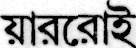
য়াররোই
